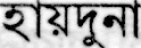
হায়দুনা
